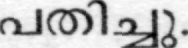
പതിച്ചു.
